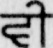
ਵੀ
